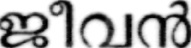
ജീവന്‍
